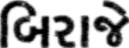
બિરાજે
